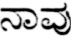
ನಾವು
